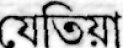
যেতিয়া
